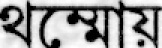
থম্মোয়
